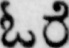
ಓರೆ
